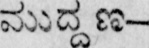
ಮುದ್ದಣ-
